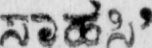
ಸಾಹಸಿ’
